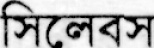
সিলেবস
